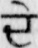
ਦੇ
